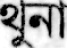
থুনা
